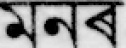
মনৰ
